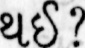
થઈ?
